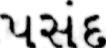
પસંદ
